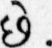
છે.
